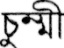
চুম্মী
